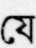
যে
